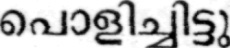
പൊളിച്ചിട്ടു
